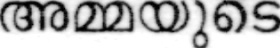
അമ്മയുടെ
